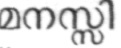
മനസ്സി
